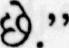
છે."
